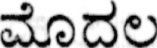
ಮೊದಲ
